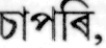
চাপৰি,
